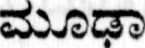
ಮೂಢಾ
